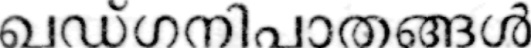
ഖഡ്ഗനിപാതങ്ങള്‍
